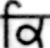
ਕਿ
